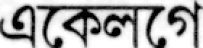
একেলগে
